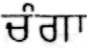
ਚੰਗਾ
